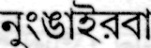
নুংঙাইরবা
